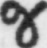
જ
